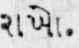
રાખો.
